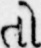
તો
